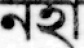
নহা
